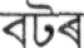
বটৰ
